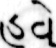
હવે
